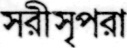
সরীসৃপরা
